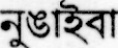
নুঙাইবা
